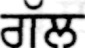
ਗੱਲ
